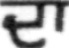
ਦਾ
